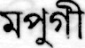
মপুগী
